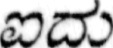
ಐದು
